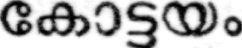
കോട്ടയം
